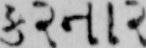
કરનાર
